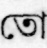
তো
